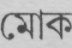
মোক
